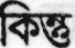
কিন্তু
